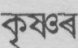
কৃষ্ণৰ
